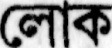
লোক
